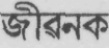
জীৱনক
